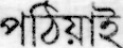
পঠিয়াই
